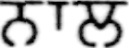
ਨਾਲ
